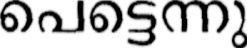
പെട്ടെന്നു
